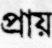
প্রায়
